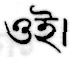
ওই।
